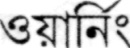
ওয়ার্নিং
